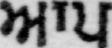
ਆਪ
